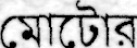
মোটোর
